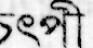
চৎপী
